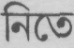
নিতে
